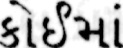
કોઈમાં
